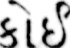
કોઈ
